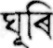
ঘূৰি
